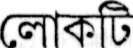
লোকটি
